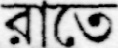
রাতে
